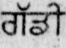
ਗੱਡੀ
